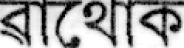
ৱাথোক
